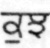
ਕੁਝ
